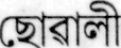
ছোৱালী
